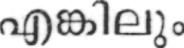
എങ്കിലും
